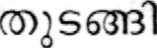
തുടങ്ങി
